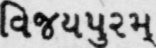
વિજયપુરમ્
